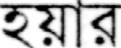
হয়ার
